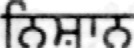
ਨਿਸ਼ਾਨ
